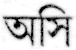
অসি
